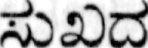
ಸುಖದ
